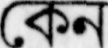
কেন
